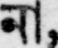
না,
